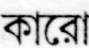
কারো
